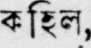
কহিল,
